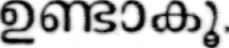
ഉണ്ടാകൂ.
